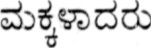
ಮಕ್ಕಳಾದರು
